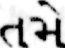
તમે
